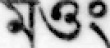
মওং
